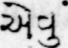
એવું
